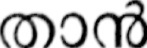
താന്‍
